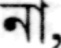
না,
